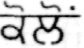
ਕੋਲੋਂ
